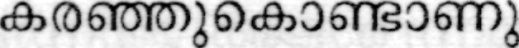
കരഞ്ഞുകൊണ്ടാണു
